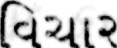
વિચાર
